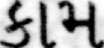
કામ
